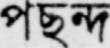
পছন্দ
